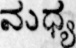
ಮಧ್ಯ
